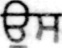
ਉਸ
